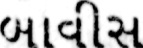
બાવીસ
